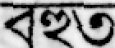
বহুত
